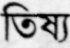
তিষ্য
